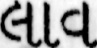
લાવ
